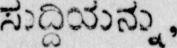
ಸುದ್ದಿಯನ್ನು,
